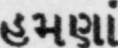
હમણાં
